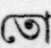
তো
